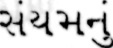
સંયમનું
